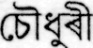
চৌধুৰী
